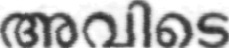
അവിടെ
